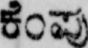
ಕೆಂಪು
